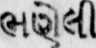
ભણેલી
